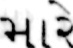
મારે
